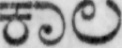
ಕಾಲ
